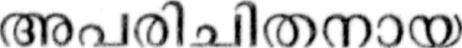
അപരിചിതനായ
